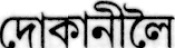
দোকানীলৈ
